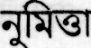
নুমিত্তা
